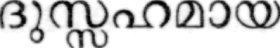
ദുസ്സഹമായ
